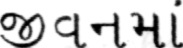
જીવનમાં
